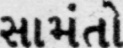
સામંતો
